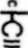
ਨੂੰ
